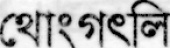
থোংগৎলি
